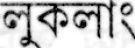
লুকলাং
